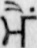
ਮੈਂ
